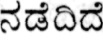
ನಡೆದಿದೆ
